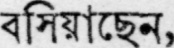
বসিয়াছেন,
